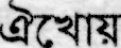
ঐখোয়
